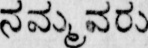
ನಮ್ಮವರು
